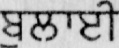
ਬੁਲਾਈ
